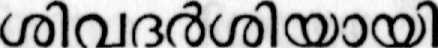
ശിവദര്‍ശിയായി
